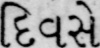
દિવસે
